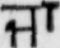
ਜਾ
